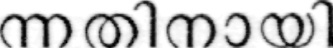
ന്നതിനായി
